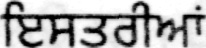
ਇਸਤਰੀਆਂ
